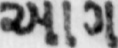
આગ
